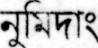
নুমিদাং
